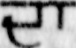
ਦਾ
